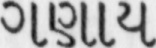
ગણાય
